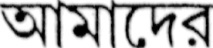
আমাদের
